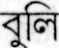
বুলি
